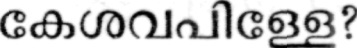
കേശവപിള്ളേ?
